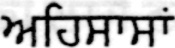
ਅਹਿਸਾਸਾਂ
